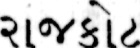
રાજકોટ
